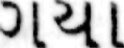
ગયા
